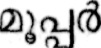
മൂപ്പര്‍
